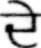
ਦੇ
